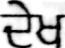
ਦੇਖ
